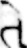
તે
